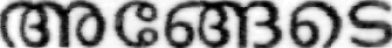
അങ്ങേടെ
